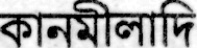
কানমীলাদি
